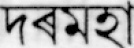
দৰমহা
